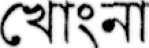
খোংনা
